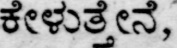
ಕೇಳುತ್ತೇನೆ,
